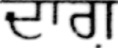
ਦਾਗ਼
